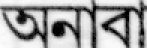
অনবা
